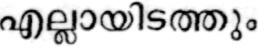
എല്ലായിടത്തും
